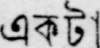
একটা
